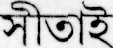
সীতাই
